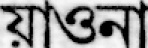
য়াওনা
